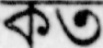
কত
